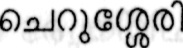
ചെറുശ്ശേരി
